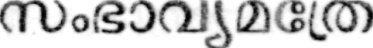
സംഭാവ്യമത്രേ
